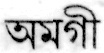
অমগী
